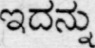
ಇದನ್ನು
